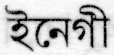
ইনেগী
